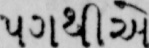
પગથીએ
